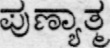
ಪುಣ್ಯಾತ್ಮ
